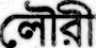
লৌরী
